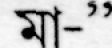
মা-"
